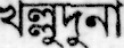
খল্লুদুনা
